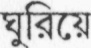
ঘুরিয়ে
